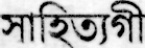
সাহিত্যগী
